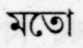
মতো
